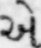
એ
